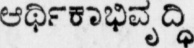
ಆರ್ಥಿಕಾಭಿವೃದ್ಧಿ
